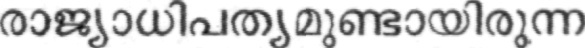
രാജ്യാധിപത്യമുണ്ടായിരുന്ന
